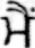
ਮੈਂ
